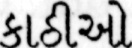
કાઠીઓ
